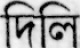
দিলি
